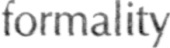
formality
